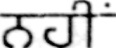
ਨਹੀਂ
